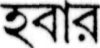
হবার
